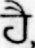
ਹੈ,
